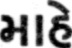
માહે
